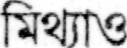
মিথ্যাও
